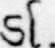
ર્ડા.
